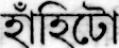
হাঁহিটো
